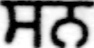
ਸਨ
